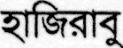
হাজিরাবু
